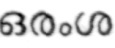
ഒരംശ
